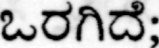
ಒರಗಿದೆ;
